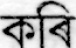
কৰি
